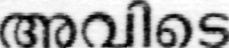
അവിടെ
